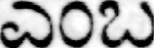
ಎಂಬ
